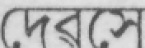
দেৱসে
